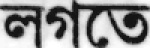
লগতে
